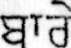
ਬਾਰੇ
